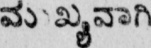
ಮುಖ್ಯವಾಗಿ
